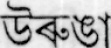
উৰুঙা
